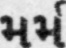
મર્મ
